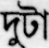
দুটা
